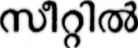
സീറ്റില്‍
